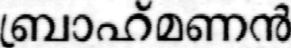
ബ്രാഹ്മണന്‍
